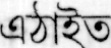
এঠাইত
